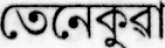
তেনেকুৱা
